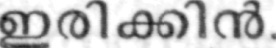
ഇരിക്കിന്‍.
